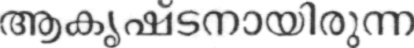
ആകൃഷ്ടനായിരുന്ന
